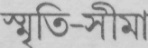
স্মৃতি-সীমা
